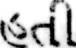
હતી
